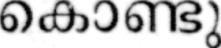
കൊണ്ടു
